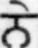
ਨੇ
